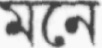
মনে
